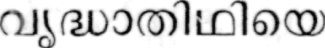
വൃദ്ധാതിഥിയെ
